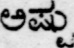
ಅಷ್ಟು
